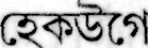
হেকউগে
